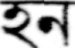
হন
